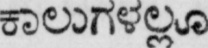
ಕಾಲುಗಳಲ್ಲೂ
